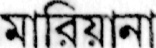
মারিয়ানা
